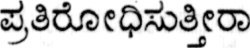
ಪ್ರತಿರೋಧಿಸುತ್ತೀರಾ
